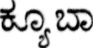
ಕ್ಯೂಬಾ
